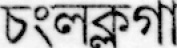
চংলক্লগা
